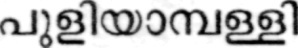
പുളിയാമ്പള്ളി
